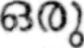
ഒരു
